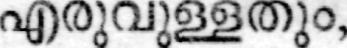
എരുവുള്ളതും,
